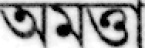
অমত্তা
